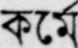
কর্মে
